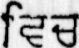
ਵਿਚ
